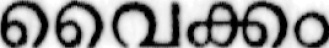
വൈക്കം
